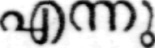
എന്നു
